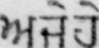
ਅਜੇਹੇ
